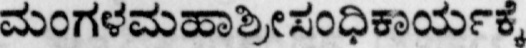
ಮಂಗಳಮಹಾಶ್ರೀಸಂಧಿಕಾರ್ಯಕ್ಕೆ
